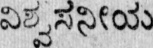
ವಿಶ್ವಸನೀಯ
